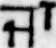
ਜਾ
